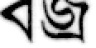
বজ্র
